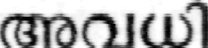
അവധി
